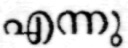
എന്നു
